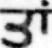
ਤਾਂ
